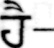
ਹੈ-
